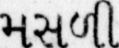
મસળી
